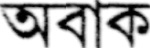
অবাক
